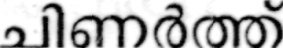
ചിണര്‍ത്ത്
